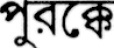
পুরক্কে
